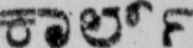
ಕಾರ್ಲ್
